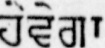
ਹੋਵੇਗਾ
